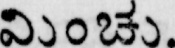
ಮಿಂಚು.
